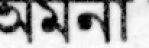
অমনা
